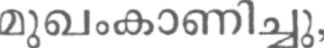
മുഖംകാണിച്ചു,
